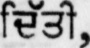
ਦਿੱਤੀ,
